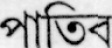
পাতিব
